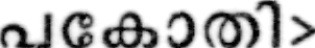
പകോതി>
